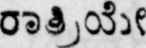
ರಾತ್ರಿಯೇ
